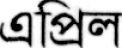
এপ্রিল
